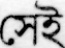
সেই
